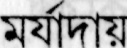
মর্যাদায়
